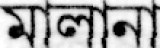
মালানা
